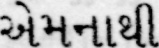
એમનાથી
